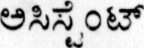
ಅಸಿಸ್ಟೆಂಟ್
